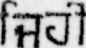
ਜਿਹੀ
